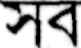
সব
